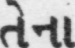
તેના
